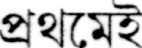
প্রথমেই
